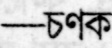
–চণক
